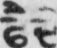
ਫੈਦੇ
